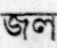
জল
